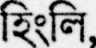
হিংলি,
